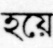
হয়ে
